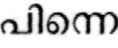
പിന്നെ
